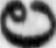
ಲ
